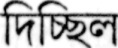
দিচ্ছিল
